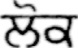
ਲੋਕ
